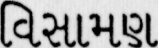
વિસામણ
